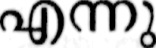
എന്നു
